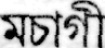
মচাগী
